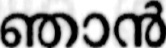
ഞാന്‍
